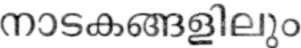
നാടകങ്ങളിലും
